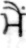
ਮੈਂ
